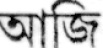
আজি
